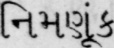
નિમણૂંક
